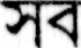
সব
